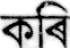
কৰি
